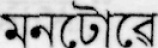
মনটোৱে
